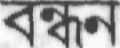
বন্ধন
